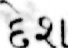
દેશ
